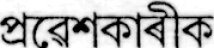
প্রৱেশকাৰীক
